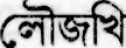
লৌজখি
